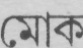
মোক
